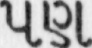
પણ
